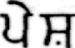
ਪੇਸ਼
